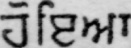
ਹੋਇਆ
